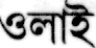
ওলাই
